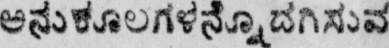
ಅನುಕೂಲಗಳನ್ನೊದಗಿಸುವ
